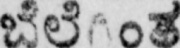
ಬೆಲೆಗಿಂತ
